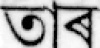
তাৰ
